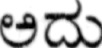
ಅದು
